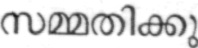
സമ്മതിക്കു
